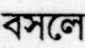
বসলে
